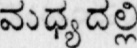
ಮಧ್ಯದಲ್ಲಿ
